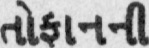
તોફાનની
